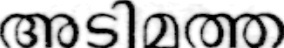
അടിമത്ത
